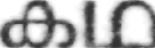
കഥ
